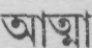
আত্মা
